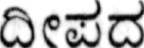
ದೀಪದ
